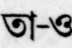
তা-ও
